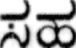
ಸಹ
